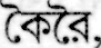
কৈরৈ,
